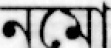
নমো
